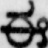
ಈ
